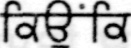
ਕਿਉਂਕਿ
